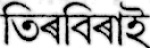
তিৰবিৰাই
